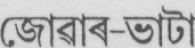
জোৱাৰ-ভাটা
